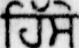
ਹਿੱਸੇ
